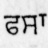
ਫਸਾ
